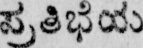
ಪ್ರತಿಭೆಯ
